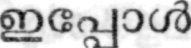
ഇപ്പോള്‍
